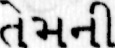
તેમની
